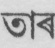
তাৰ
